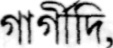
গার্গীদি,
